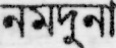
নমদুনা
